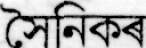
সৈনিকৰ
